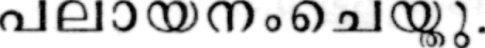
പലായനംചെയ്തു.
